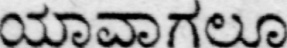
ಯಾವಾಗಲೂ
